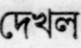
দেখল
